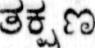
ತಕ್ಷಣ
